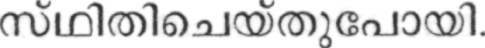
സ്ഥിതിചെയ്തുപോയി.
